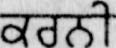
ਕਰਨੀ
